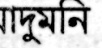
যাদুমনি
